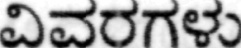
ವಿವರಗಳು
